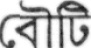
বৌটি
